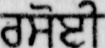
ਰਸੋਈ
